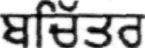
ਬਚਿੱਤਰ
